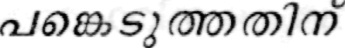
പങ്കെടുത്തതിന്
